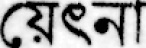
য়েৎনা
